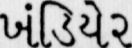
ખંડિયેર
